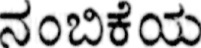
ನಂಬಿಕೆಯ
